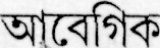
আবেগিক
